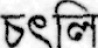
চৎলি
